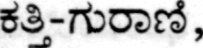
ಕತ್ತಿ-ಗುರಾಣಿ,
